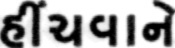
હીંચવાને
